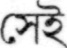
সেই
